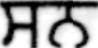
ਸਨ
